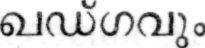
ഖഡ്ഗവും
